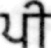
ਪੀ
